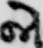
જો
